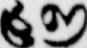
હજી
